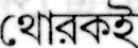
থোরকই
